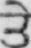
ਤੇ
